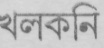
খলকনি
